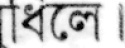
সুধিলে।
